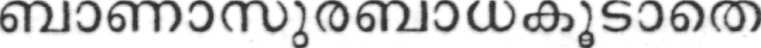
ബാണാസുരബാധകൂടാതെ
